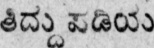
ತಿದ್ದುಪಡಿಯ
